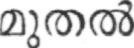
മുതല്‍
